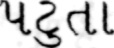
પટુતા
